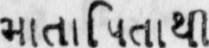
માતાપિતાથી
